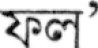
ফল'
